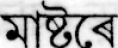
মাষ্টৰে
